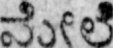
ಮೇಲೆ
